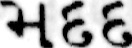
મદદ
